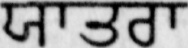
ਯਾਤਰਾ
